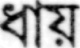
ধায়
